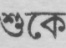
শুকে
